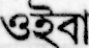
ওইবা
